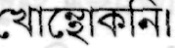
খোন্থোকনি।
